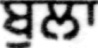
ਬੁਲਾ
